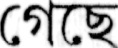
গেছে
